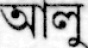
আলু
